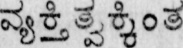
ವ್ಯಕ್ತಿತ್ವಕ್ಕಿಂತ
